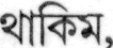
থাকিম,
